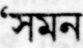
‘সমন
